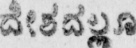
ದೇಶದಲ್ಲೂ
